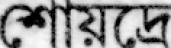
শোয়দ্রে,
